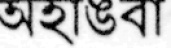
অহাঙবা
